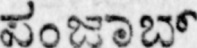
ಪಂಜಾಬ್
